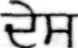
ਦੇਸ
